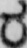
ರ
